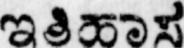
ಇತಿಹಾಸ
